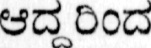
ಆದ್ದರಿಂದ
